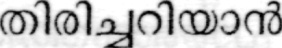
തിരിച്ചറിയാന്‍
